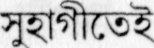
সুহাগীতেই
